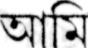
আমি
